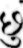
છું
